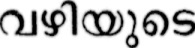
വഴിയുടെ
